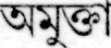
অমুক্তা
